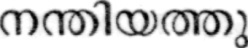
നന്തിയത്തു
